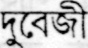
দুবেজী
